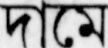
দামে
